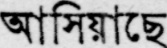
আসিয়াছে
